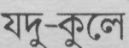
যদু-কুলে
